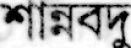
শান্নবদু
